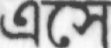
এসে
